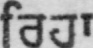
ਰਿਹਾ
